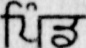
ਪਿੰਡ
